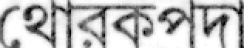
থোরকপদা
